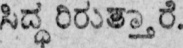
ಸಿದ್ಧರಿರುತ್ತಾರೆ.
